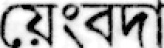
য়েংবদা
